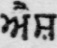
ਐਸ਼
